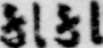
કાકા
